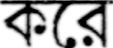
করে
